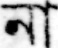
না
